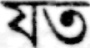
যত
